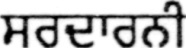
ਸਰਦਾਰਨੀ
